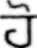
ਹੋ
